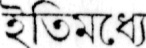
ইতিমধ্যে
